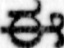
ಈ
